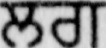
ਲਗ
